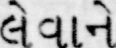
લેવાને
